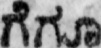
ಗೆಗೂ
